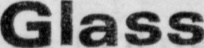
Glass
